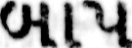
બાપ
